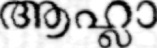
ആഹ്ലാ
